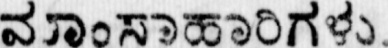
ಮಾಂಸಾಹಾರಿಗಳು.
